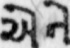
એને
